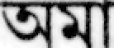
অমা
